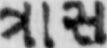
ત્રાસ
